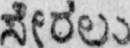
ಸೇರಲು
